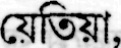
য়েতিয়া,
